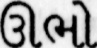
ઊભો
